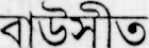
বাউসীত
